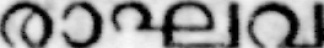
രാഘവ
